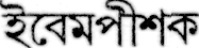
ইবেমপীশক
